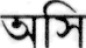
অসি
